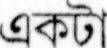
একটা
